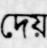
দেয়
